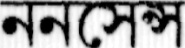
ননসেন্স
